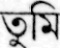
তুমি
